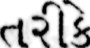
તરીકે
